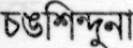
চঙশিন্দুনা
